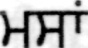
ਮਸਾਂ
